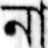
না
